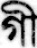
গী
